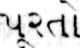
પૂરતો
